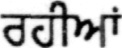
ਰਹੀਆਂ
